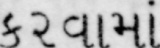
કરવામાં
